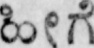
ಹೀಗೆ
